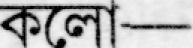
কলো-
